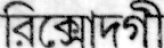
রিক্সোদগী
